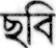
ছবি
